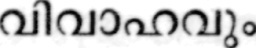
വിവാഹവും
